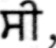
ਸੀ,
